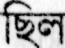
ছিল
